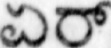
ಏರ್
